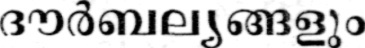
ദൌര്‍ബല്യങ്ങളും
